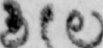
ಶೀಲ
